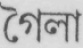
গৈলা
